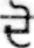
ਦੋ
